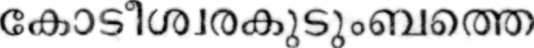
കോടീശ്വരകുടുംബത്തെ
